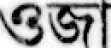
ওজা
